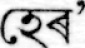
হেৰ'
